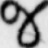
જ
